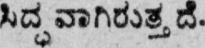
ಸಿದ್ಧವಾಗಿರುತ್ತದೆ.
